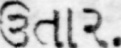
ઉતાર.
